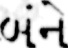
બંને
